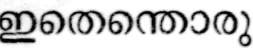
ഇതെന്തൊരു
